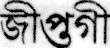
জীপ্তগী
